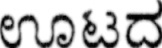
ಊಟದ
